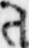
તે
